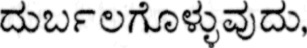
ದುರ್ಬಲಗೊಳ್ಳುವುದು,
